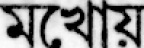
মখোয়
